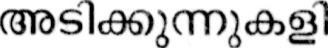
അടിക്കുന്നുകളി
